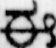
ಈ
